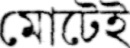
মোটেই
